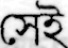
সেই
